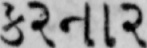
કરનાર
